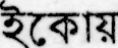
ইকোয়
